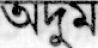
অদুম
